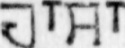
ਹਾਸਾ
